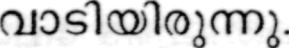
വാടിയിരുന്നു.
